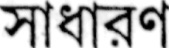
সাধারণ
